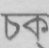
চক্
